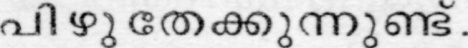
പിഴുതേക്കുന്നുണ്ട്.
